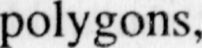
polygons,
